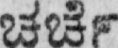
ಚರ್ಚೆ
